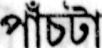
পাঁচটা
